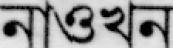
নাওখন
